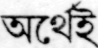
অর্থেই
